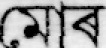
মোৰ
